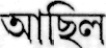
আছিল
